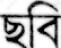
ছবি
